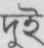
দুই
